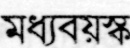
মধ্যবয়স্ক
